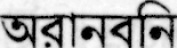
অরানবনি
